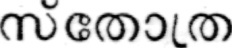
സ്തോത്ര
